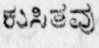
ಕುಸಿತವು
